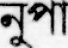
নুপা
